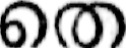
തെ
